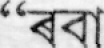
"ৰবা
